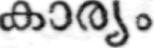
കാര്യം
